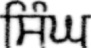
ਸਿੰਘ
